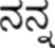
ನನ್ನ
